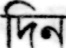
দিন
